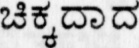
ಚಿಕ್ಕದಾದ
